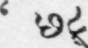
'છટ
